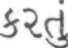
કરતું
